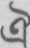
ঐ
